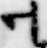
ન
